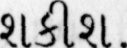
શકીશ.
